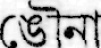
ঙৌনা
